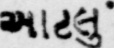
આટલું
